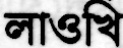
লাওখি
